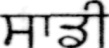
ਸਾਡੀ
